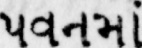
પવનમાં
